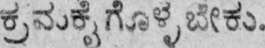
ಕ್ರಮಕೈಗೊಳ್ಳಬೇಕು.
